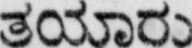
ತಯಾರು
